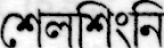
শেলশিংনি
